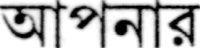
আপনার
